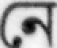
নে
